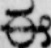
ಈ
